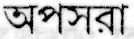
অপসরা
